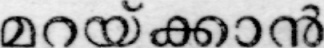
മറയ്ക്കാന്‍
